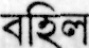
বহিল
